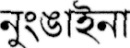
নুংঙাইনা
